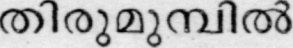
തിരുമുമ്പില്‍
